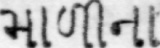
માળીના
